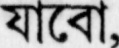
যাবো,
